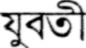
যুবতী
